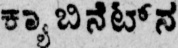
ಕ್ಯಾಬಿನೆಟ್‌ನ
